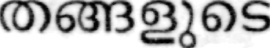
തങ്ങളുടെ
